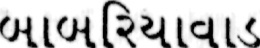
બાબરિયાવાડ
